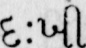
દઃખી
